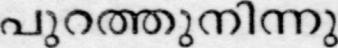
പുറത്തുനിന്നു
